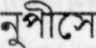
নুপীসে
